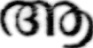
ആ
